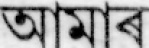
আমাৰ
